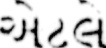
એટલે
